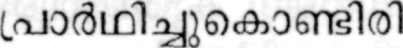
പ്രാര്‍ഥിച്ചുകൊണ്ടിരി
